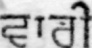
ਵਾਰੀ
